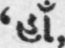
'હાઁ,
